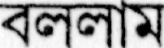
বললাম
